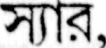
স্যার,
